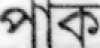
পাক
